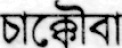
চাক্কৌবা
